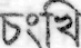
চংখি
